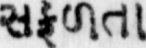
સફળતા
